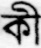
কী
